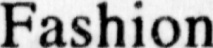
Fashion
